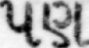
પણ
